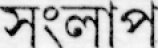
সংলাপ
